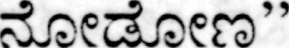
ನೋಡೋಣ"
